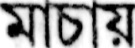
মাচায়
